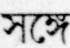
সঙ্গে
